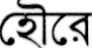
হৌরে
